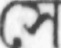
সে
